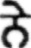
ਨੇ
